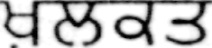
ਖ਼ਲਕਤ
